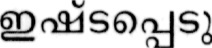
ഇഷ്ടപ്പെടു
